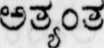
ಅತ್ಯಂತ
